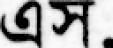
এস.
